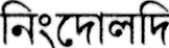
নিংদোলদি
